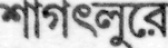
শাগৎলুরে
